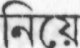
নিয়ে
